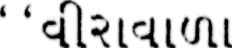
"વીરાવાળા
